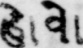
હોવા
